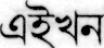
এইখন
